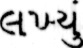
લખ્યું
